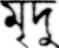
মৃদু
